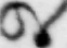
જ
